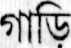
গাড়ি
